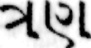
ત્રણ
